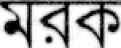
মরক
